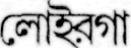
লোইরগা
